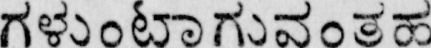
ಗಳುಂಟಾಗುವಂತಹ
